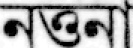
নত্তনা
